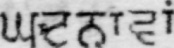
ਘਟਨਾਵਾਂ
